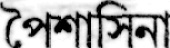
পৈশাসিনা
